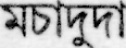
মচাদুদা
